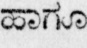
ಹಾಗೂ
